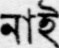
নাই
